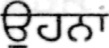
ਉਹਨਾਂ
